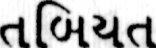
તબિયત
